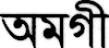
অমগী
